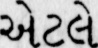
એટલે
